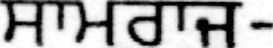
ਸਾਮਰਾਜ-
